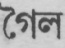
গৈল
